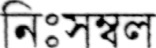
নিঃসম্বল
